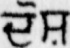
ਦੋਸ਼
